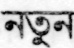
নতুন
